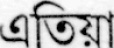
এতিয়া
